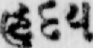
હ્રદય
